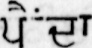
ਪੈਂਦਾ
